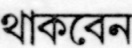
থাকবেন
